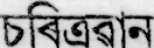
চৰিত্রৱান
